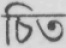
চিত
